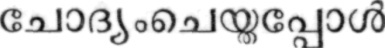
ചോദ്യംചെയ്തപ്പോള്‍
